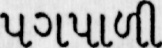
પગપાળી
